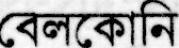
বেলকোনি
